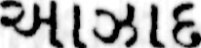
આઝાદ
